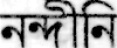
নন্দীনি
